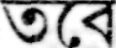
তবে
